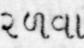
રળવા
